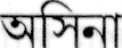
অসিনা
